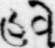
હવે
